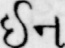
ઈન
